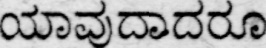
ಯಾವುದಾದರೂ
